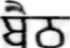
ਬੈਠ
